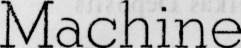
Machine
